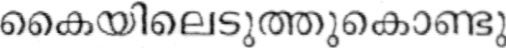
കൈയിലെടുത്തുകൊണ്ടു
